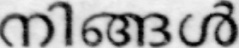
നിങ്ങള്‍
